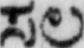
ಸಲ
